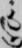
હું
